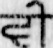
ਵੀ
